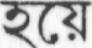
হয়ে
